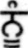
ਨੂੰ
